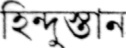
হিন্দুস্তান
